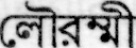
লৌরম্মী
